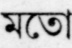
মতো
